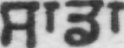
ਸਾਡਾ
